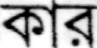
কার
